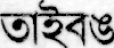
তাইবঙ
